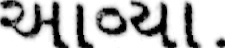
આવ્યા.
